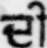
ਦੀ
